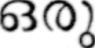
ഒരു
